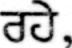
ਰਹੇ,
